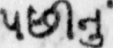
પછીનું
